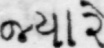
જ્યારે
